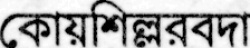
কোয়শিল্লরবদা
